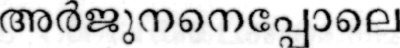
അര്‍ജുനനെപ്പോലെ
